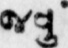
જવું
